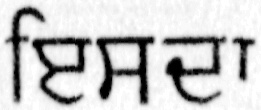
ਇਸਦਾ
